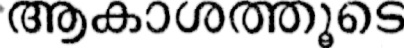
ആകാശത്തൂടെ
